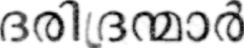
ദരിദ്രന്മാര്‍
